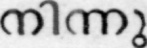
നിന്നു
